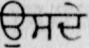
ਉਸਦੇ
